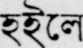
হইলে
